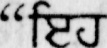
''ਇਹ
